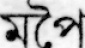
মপৈ
